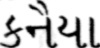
કનૈયા
